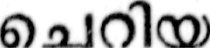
ചെറിയ
